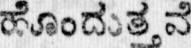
ಹೊಂದುತ್ತವೆ
